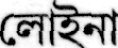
লোইনা
